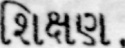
શિક્ષણ,
